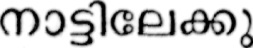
നാട്ടിലേക്കു
